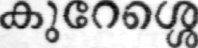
കുറേശ്ശെ
